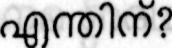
എന്തിന്?
